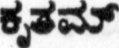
ಕೃತಮ್
